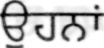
ਉਹਨਾਂ
